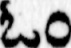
ಓಂ
